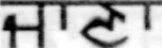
ਜਾਣਾ
